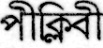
পীক্লিবী
